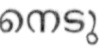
നെടു
